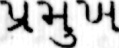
પ્રમુખ
